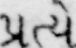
પ્રત્યે
